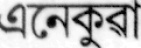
এনেকুৱা
